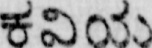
ಕವಿಯ
